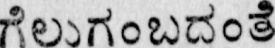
ಗೆಲುಗಂಬದಂತೆ
